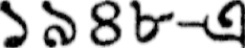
১৯৪৮-এ
